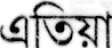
এতিয়া
